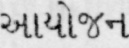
આયોજન
